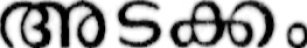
അടക്കം
